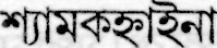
শ্যামকহ্ণাইনা
